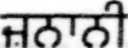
ਜ਼ਨਾਨੀ
